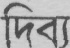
দিব্য
